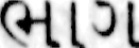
ભાગ
